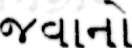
જવાનો
